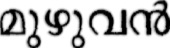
മുഴുവന്‍
